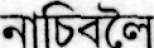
নাচিবলৈ
